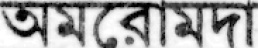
অমরোমদা
